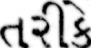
તરીકે
